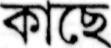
কাছে
